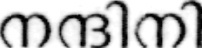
നന്ദിനി
